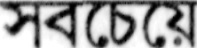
সবচেয়ে
